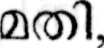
മതി,
